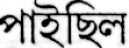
পাইছিল
